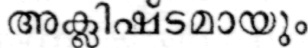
അക്ലിഷ്ടമായും
